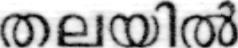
തലയില്‍
